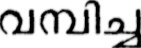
വമ്പിച്ച
